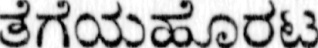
ತೆಗೆಯಹೊರಟ
